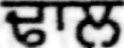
ਢਾਲ
